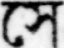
সে
